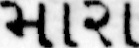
મારા
